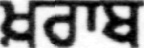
ਖ਼ਰਾਬ
